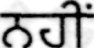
ਨਹੀਂ
